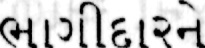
ભાગીદારને
